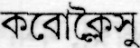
কবোক্লৈসু
